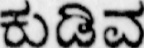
ಕುಡಿವ
